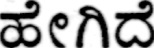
ಹೇಗಿದೆ
